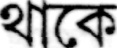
থাকে
